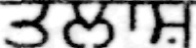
ਤਲਾਸ਼
